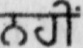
ਨਹੀਂ
